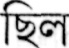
ছিল
